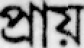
প্রায়
